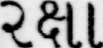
રક્ષા
